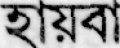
হায়বা
